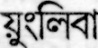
য়ুংলিবা
